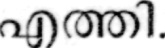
എത്തി.
